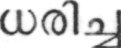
ധരിച്ച
